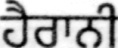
ਹੈਰਾਨੀ
